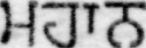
ਮਹਾਨ
